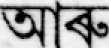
আৰু
